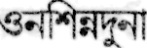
ওনশিন্নদুনা
